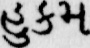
હુકમ
